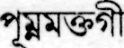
পূম্নমক্তগী
